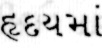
હ્રદયમાં
